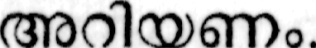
അറിയണം.
